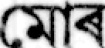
মোৰ
